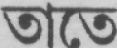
তাতে
